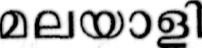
മലയാളി
